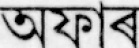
অফাৰ
